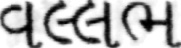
વલ્લભ
